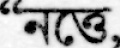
“নত্তে,
